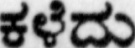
ಕಳೆದು
